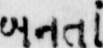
બનતાં
